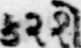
કરશે
